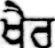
ਖੈਰ
